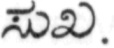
ಸುಖ.
